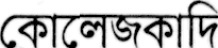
কোলেজকাদি
